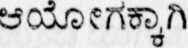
ಆಯೋಗಕ್ಕಾಗಿ
